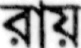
রায়
